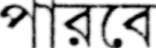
পারবে
